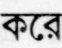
করে
